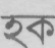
হক
